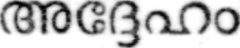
അദ്ദേഹം
